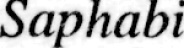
Saphabi
